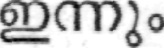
ഇന്നും
